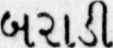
બરાડી
